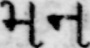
મન
